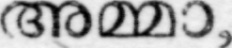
അമ്മാ,
